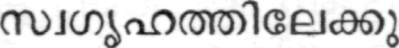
സ്വഗൃഹത്തിലേക്കു
